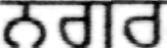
ਨਗਰ
